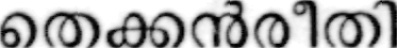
തെക്കന്‍രീതി
